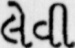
લેવી
